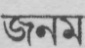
জনম
